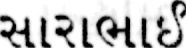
સારાભાઈ
